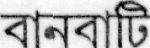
বানবাটি
